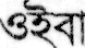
ওইবা
